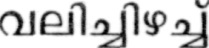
വലിച്ചിഴച്ച്
